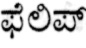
ಫೆಲಿಪ್
